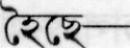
হৈছে-
